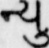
ન્યુ
